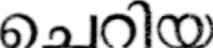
ചെറിയ
